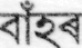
বাঁহৰ
